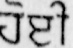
ਹੋਈ
